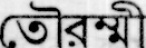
তৌরম্মী
